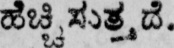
ಹೆಚ್ಚಿಸುತ್ತದೆ.
